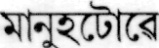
মানুহটোৱে
